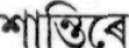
শান্তিৰে
